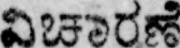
ವಿಚಾರಣೆ
